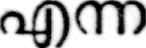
എന്ന
